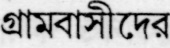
গ্রামবাসীদের
